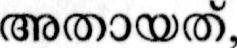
അതായത്,
